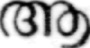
ആ
